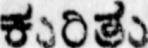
ಕುರಿತು
